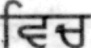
ਵਿਚ
